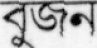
বুজন
